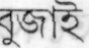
বুজাই
